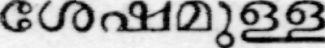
ശേഷമുള്ള
